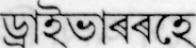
ড্ৰাইভাৰৰহে
